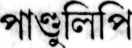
পাণ্ডুলিপি
